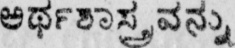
ಅರ್ಥಶಾಸ್ತ್ರವನ್ನು
